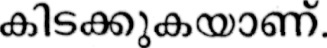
കിടക്കുകയാണ്.
